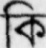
কি
